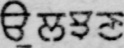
ਉਲਝਣ
